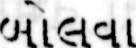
બોલવા
